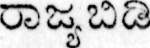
ರಾಜ್ಯಬಿಡಿ
